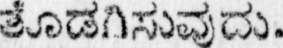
ತೊಡಗಿಸುವುದು.
